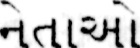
નેતાઓ
